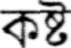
কষ্ট
